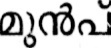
മുന്‍പ്
